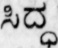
ಸಿದ್ಧ
